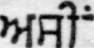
ਅਸੀਂ
